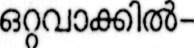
ഒറ്റവാക്കില്‍-
